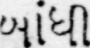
બાંધી
